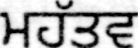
ਮਹੱਤਵ
